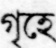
গৃহে
